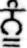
ਨੂੰ
